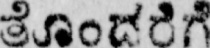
ತೊಂದರೆಗೆ
